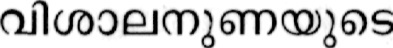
വിശാലനുണയുടെ
